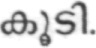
കൂടി.
